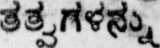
ತತ್ವಗಳನ್ನು
